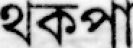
থকপা
